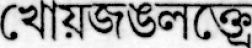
খোয়জঙলক্ত্রে
